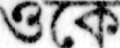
ওকে
